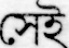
সেই
